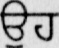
ਉਹ
